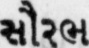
સૌરભ
